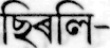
ছিৰলি-
